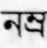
নম্র
